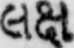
લક્ષ
